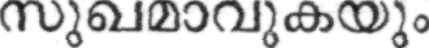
സുഖമാവുകയും
